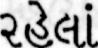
રહેલાં
